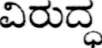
ವಿರುದ್ಧ
